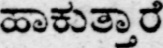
ಹಾಕುತ್ತಾರೆ
